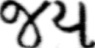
જય
